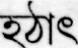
হঠাৎ
